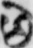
છે
